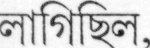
লাগিছিল,
